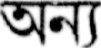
অন্য
